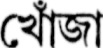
খোঁজা
